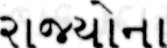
રાજ્યોના
